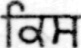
ਕਿਸ
